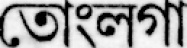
তোংলগা
